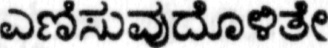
ಎಣಿಸುವುದೊಳಿತೇ
